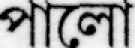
পালো
